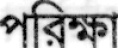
পরিক্ষা
